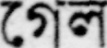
গেল
